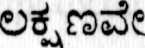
ಲಕ್ಷಣವೇ
